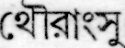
থৌরাংসু
